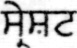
ਸ੍ਰੇਸ਼ਟ
